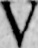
V
